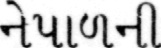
નેપાળની
